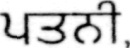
ਪਤਨੀ,
